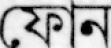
ফোন
